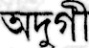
অদুগী
